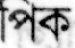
পিক
